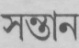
সন্তান
